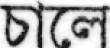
চালে
